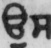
ਉਸ
